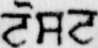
ਟੋਸਟ
